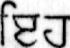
ਇਹ
